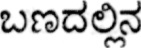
ಬಣದಲ್ಲಿನ
